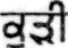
ਕੁੜੀ
